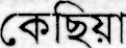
কেছিয়া
